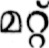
മറ്റ്
